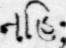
નહિ;
